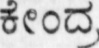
ಕೇಂದ್ರ
